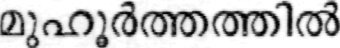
മുഹൂര്‍ത്തത്തില്‍
